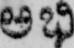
ಅಭಿ
